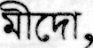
মীদো,
